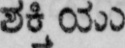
ಶಕ್ತಿಯು
